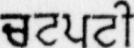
ਚਟਪਟੀ
